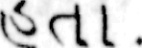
હતા.
